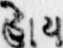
હોય
